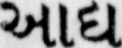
આદ્ય
